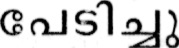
പേടിച്ചു
